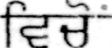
ਵਿਚੋਂ
